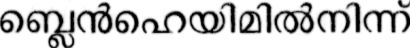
ബ്ലെന്‍ഹെയിമില്‍നിന്ന്
